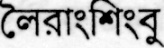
লৈরাংশিংবু
